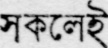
সকলেই
